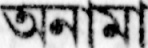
অনামা
